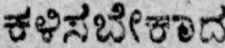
ಕಳಿಸಬೇಕಾದ
